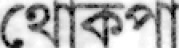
থোকপা
